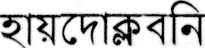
হায়দোক্লবনি
